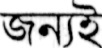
জন্যই
